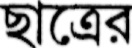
ছাত্রের
